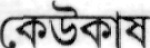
কেউকাষ
